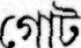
গোট
